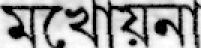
মখোয়না
